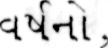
વર્ષનો,
